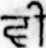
ਵੀ
